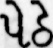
પેઠે
